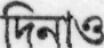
দিনাও
